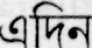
এদিন
